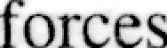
forces
